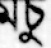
মচু
